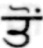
ਤੋਂ
